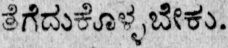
ತೆಗೆದುಕೊಳ್ಳಬೇಕು.
